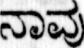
ನಾವು
